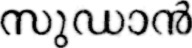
സുഡാന്‍
